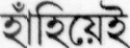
হাঁহিয়েই
